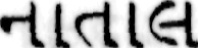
નાતાલ
